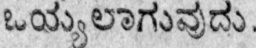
ಒಯ್ಯಲಾಗುವುದು.
